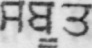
ਸਬੂਤ
